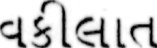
વકીલાત
